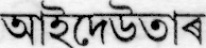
আইদেউতাৰ
